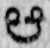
ಆ
